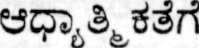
ಆಧ್ಯಾತ್ಮಿಕತೆಗೆ
